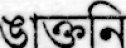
ঙাক্তনি
